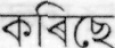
কৰিছে
